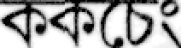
ককচেং
